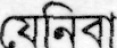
যেনিবা
